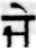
ਜੇ
